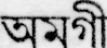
অমগী
